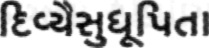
દિવ્યૈસુધૂપિતા
